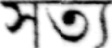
সত্য
